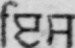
ਇਸ
